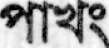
পাখং
